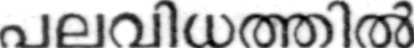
പലവിധത്തില്‍
